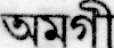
অমগী
